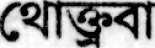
থোক্ত্রবা
